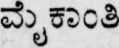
ಮೈಕಾಂತಿ
